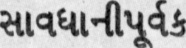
સાવધાનીપૂર્વક
